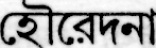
হৌরেদনা
